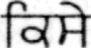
ਕਿਸੇ
